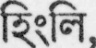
হিংলি,
